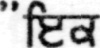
''ਇਕ
